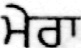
ਮੇਰਾ
